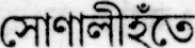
সোণালীহঁতে
